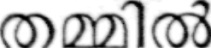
തമ്മില്‍
